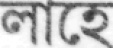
লাহে
